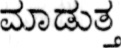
ಮಾಡುತ್ತ
